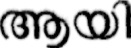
ആയി
